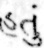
હતું
